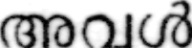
അവള്‍
